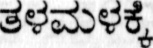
ತಳಮಳಕ್ಕೆ
